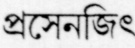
প্রসেনজিত্
